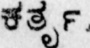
ಕರ್ತೃ.
